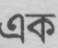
এক
